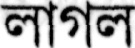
লাগল
